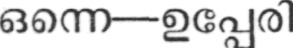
ഒന്നെ-ഉപ്പേരി
